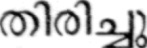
തിരിച്ചു
